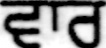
ਵਾਰ
